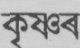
কৃষ্ণৰ
